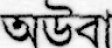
অউবা
